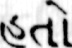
હતો
